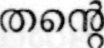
തന്റെ
